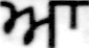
ਆ
